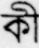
কী
